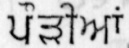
ਪੌਡੀਆਂ
